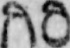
ಗಿರಿ
